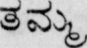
ತಮ್ಮ
